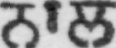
ਨਾਲ
